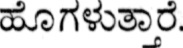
ಹೊಗಳುತ್ತಾರೆ.
